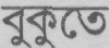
বুকুতে
